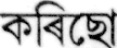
কৰিছো
